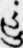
હું
